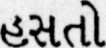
હસતો
